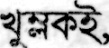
খুম্লকই,
